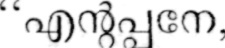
"എന്റപ്പനേ,
